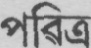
পৱিত্র
